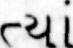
ત્યાં
